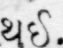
થઈ.
